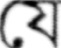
যে
